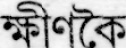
ক্ষীণকৈ
